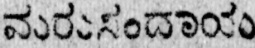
ಮರುಸಂದಾಯ
